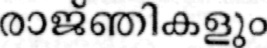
രാജ്ഞികളും
